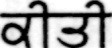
ਕੀਤੀ
